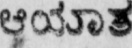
ಆಯಾತ
